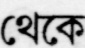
থেকে
